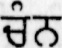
ਚੰਨ
